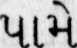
પામે
